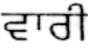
ਵਾਰੀ
